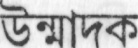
উন্মাদক
